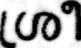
ശ്രീ
